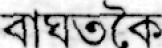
বাঘতকৈ
